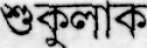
শুকুলাক
